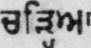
ਚੜ੍ਹਿਆ
